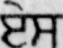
ਏਸ
